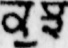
ਕੁਝ
